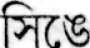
সিঙে
